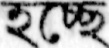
হচ্ছে
